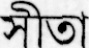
সীতা
